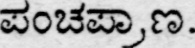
ಪ೦ಚಪ್ರಾಣ.
